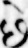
છે
